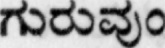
ಗುರುವುಂ
